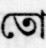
তো
